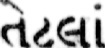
તેટલાં
